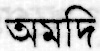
অমদি
